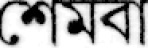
শেমবা
